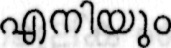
എനിയും
